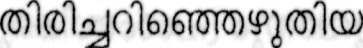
തിരിച്ചറിഞ്ഞെഴുതിയ
